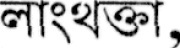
লাংথক্তা,
